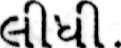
લીધી.
